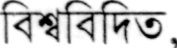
বিশ্ববিদিত,
